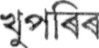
খুপৰিৰ
